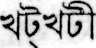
খট্‌খটী
